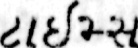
ટાઇમ્સ
